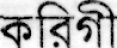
করিগী
